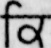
ਕਿ
